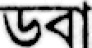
ডবা
